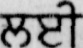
ਲਈ
